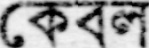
কেবল
